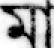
মা
